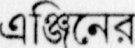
এঞ্জিনের
